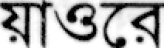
য়াওরে
